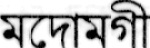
মদোমগী
